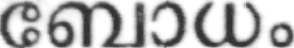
ബോധം
